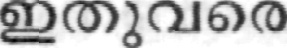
ഇതുവരെ
